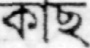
কাছ
